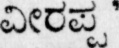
ವೀರಪ್ಪ’
